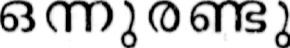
ഒന്നുരണ്ടു
